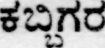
ಕಬ್ಬಿಗರ
